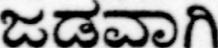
ಜಡವಾಗಿ
